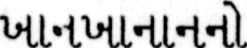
ખાનખાનાનનો
